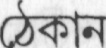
ঠেকান
